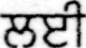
ਲਈ
